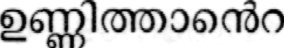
ഉണ്ണിത്താന്റെ
